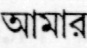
আমার
